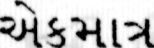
એકમાત્ર
